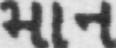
માન
